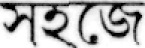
সহজে
